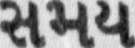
સમય
